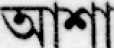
আশা
